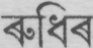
ৰুধিৰ
